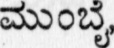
ಮುಂಬೈ,
